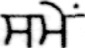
ਸਮੇਂ
